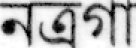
নত্রগা
